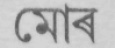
মোৰ
